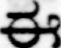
ಈ
